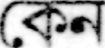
কেন
